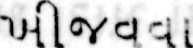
ખીજવવા
